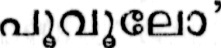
പൂവൂലോ’
